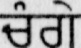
ਚੰਗੇ
